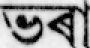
ভৰা
